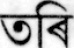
তৰি
